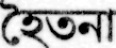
হৈতনা
